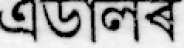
এডালৰ
